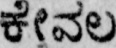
ಕೇವಲ
